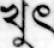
খুৎ
